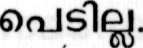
പെടില്ല.
